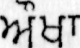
ਔਖਾ
